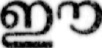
ഈ
